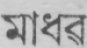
মাধৱ
